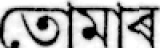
তোমাৰ
